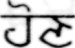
ਹੋਣ
